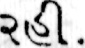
રહી.
